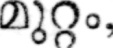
മുറ്റം,
